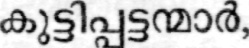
കുട്ടിപ്പട്ടന്മാര്‍,
